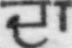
ਦਾ
